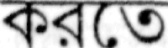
করতে
